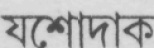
যশোদাক
